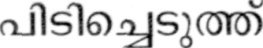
പിടിച്ചെടുത്ത്
